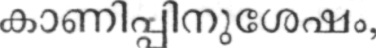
കാണിപ്പിനുശേഷം,
